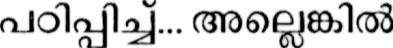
പഠിപ്പിച്ച്...അല്ലെങ്കില്‍
